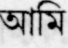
আমি
